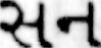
સન
